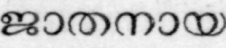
ജാതനായ
